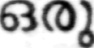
ഒരു
